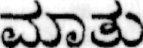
ಮಾತು
